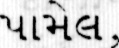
પામેલ,
